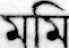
মমি
